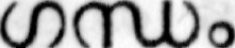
ഗന്ധം
